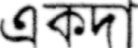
একদা
